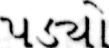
પડયો
